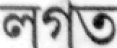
লগত
